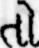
તો
